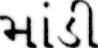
માંડી
